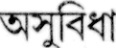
অসুবিধা
